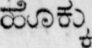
ಹೊಕ್ಕು
